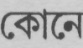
কোনে
